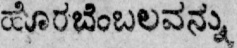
ಹೊರಬೆಂಬಲವನ್ನು
